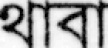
থাবা
